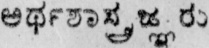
ಅರ್ಥಶಾಸ್ತ್ರಜ್ಞರು
